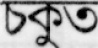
চকুত
